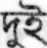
দুই
